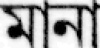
মানা
